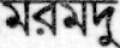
মরমদু
